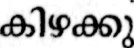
കിഴക്കു
